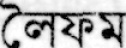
লৈফম
